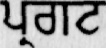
ਪ੍ਰਗਟ
